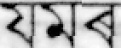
যমৰ
